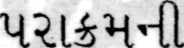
પરાક્રમની
